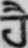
ਹੈ
